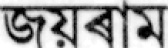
জয়ৰাম
